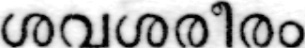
ശവശരീരം
